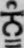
ਨੂੰ
